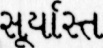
સૂર્યાસ્ત
